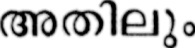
അതിലും
